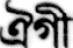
ঐগী
